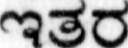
ಇತರ
